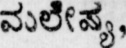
ಮಲೇಷ್ಯ,
